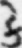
કે
